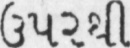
ઉપરથી
